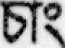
চাং
